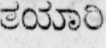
ತಯಾರಿ
